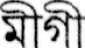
মীগী
